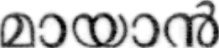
മായാന്‍
